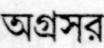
অগ্রসর
